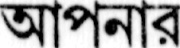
আপনার
